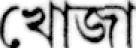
খোজা
